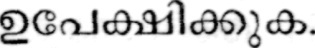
ഉപേക്ഷിക്കുക.
